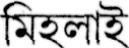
মিহলাই
